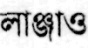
লাঞ্জাও
